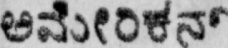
ಅಮೇರಿಕನ್
